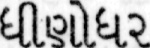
ધીણોધર
